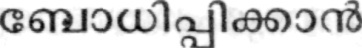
ബോധിപ്പിക്കാന്‍
